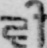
ਵੀ
